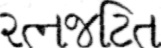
રત્નજટિત
